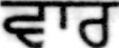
ਵਾਰ
